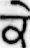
ਕੇ
